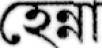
হেন্না
